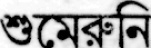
শুমেরুনি
